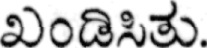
ಖಂಡಿಸಿತು.
